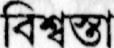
বিশ্বস্তা
